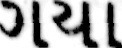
ગયા
